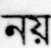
নয়
